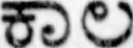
ಕಾಲ
